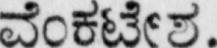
ವೆಂಕಟೇಶ.
